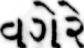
વગેરે
